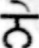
ਨੇ
